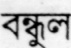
বন্ধুল
